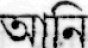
আনি
